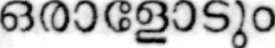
ഒരാളോടും
